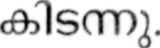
കിടന്നു.
